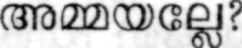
അമ്മയല്ലേ?
